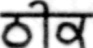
ਠੀਕ
